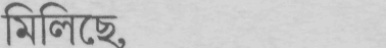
মিলিছে,
